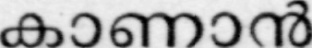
കാണാന്‍
